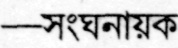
–সংঘনায়ক
